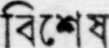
বিশেষ
